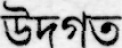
উদগত
